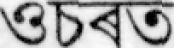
ওচৰত
